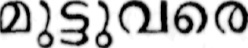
മുട്ടുവരെ
